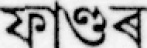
ফাণ্ডৰ
